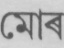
মোৰ
